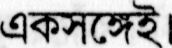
একসঙ্গেই।
